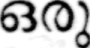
ഒരു
